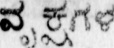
ವೃಕ್ಷಗಳ
